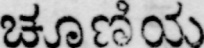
ಚೂಣಿಯ
